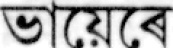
ভায়েৰে
